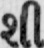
શી
